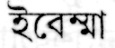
ইবেম্মা
